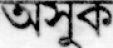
অসুক
